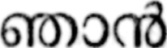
ഞാന്‍
